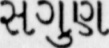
સગુણ
